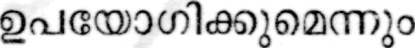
ഉപയോഗിക്കുമെന്നും
